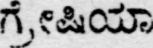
ಗ್ರೇಷಿಯಾ
